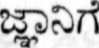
ಜ್ಞಾನಿಗೆ
